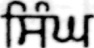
ਸਿੰਘ
